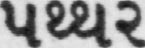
પથ્થર
